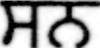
ਸਨ
